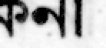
কনা
